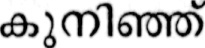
കുനിഞ്ഞ്
